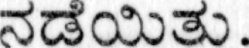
ನಡೆಯಿತು.
